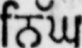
ਨਿੱਘ
